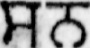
ਸਨ
